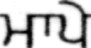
ਮਾਪੇ
